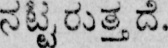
ನಟ್ಟಿರುತ್ತದೆ.
